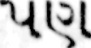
પણ
